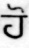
ਹੋ
